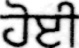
ਹੋਈ
